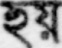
হয়
